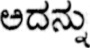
ಅದನ್ನು
